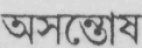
অসন্তোষ
